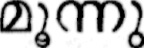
മൂന്നു
